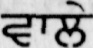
ਵਾਲੇ
